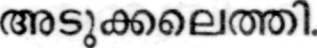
അടുക്കലെത്തി.
